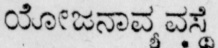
ಯೋಜನಾವ್ಯವಸ್ಥೆ
